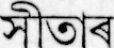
সীতাৰ
